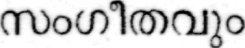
സംഗീതവും
